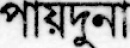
পায়দুনা
